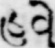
હવે
